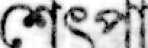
শেৎপা
